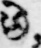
છે,
